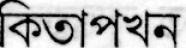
কিতাপখন
